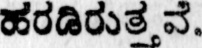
ಹರಡಿರುತ್ತವೆ.
